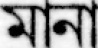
মানা
